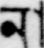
না
